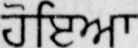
ਹੋਇਆ
